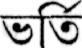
ভর্তি
